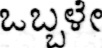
ಒಬ್ಬಳೇ
